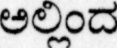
ಅಲ್ಲಿಂದ
